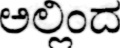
ಅಲ್ಲಿಂದ
